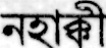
নহাক্কী
